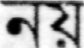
নয়
